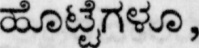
ಹೊಟ್ಟೆಗಳೂ,
